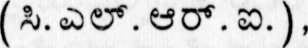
(ಸಿ.ಎಲ್.ಆರ್.ಐ.),
